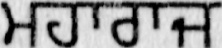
ਮਹਾਰਾਜ
